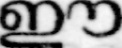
ഈ
